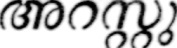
അറസ്റ്റു
